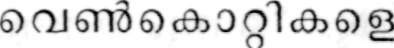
വെണ്‍കൊറ്റികളെ
